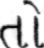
તો
